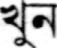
খুন
